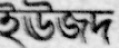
ইঊজদ
